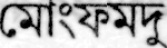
মোংফমদু
